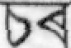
চৰ
